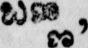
ಬಣ್ಣ,
